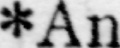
*An
